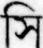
সি
